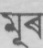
মূৰ
